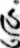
હું
